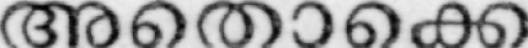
അതൊക്കെ
